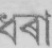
ধৰা
